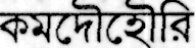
কমদৌহৌরি
